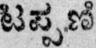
ಟಿಪ್ಪಣಿ
